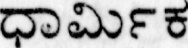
ಧಾರ್ಮಿಕ
